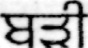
ਬੜੀ
